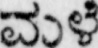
ಮಳೆ
